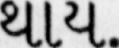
થાય.
